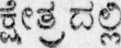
ಕ್ಷೇತ್ರದಲ್ಲಿ
